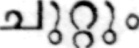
ചുറ്റും
